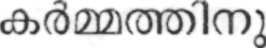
കര്‍മ്മത്തിനു
